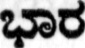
ಭಾರ
